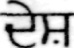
ਦੇਸ਼
